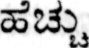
ಹೆಚ್ಚು
